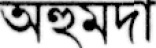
অহুমদা
